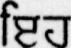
ਇਹ
